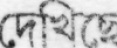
দেখিছে
